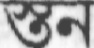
স্তন
